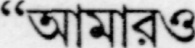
“আমারও
